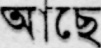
আছে
